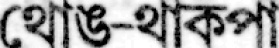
থোঙ-থাকপা
